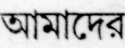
আমাদের
